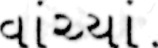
વાંચ્યાં.
